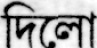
দিলো
